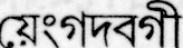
য়েংগদবগী
